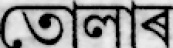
তোলাৰ
